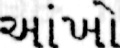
આંખો
